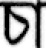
চা
